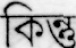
কিন্তু
